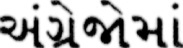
અંગ્રેજોમાં
